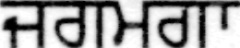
ਜਗਮਗਾ
